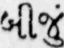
બીજું
